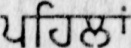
ਪਹਿਲਾਂ
